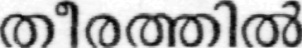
തീരത്തില്‍
